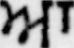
ਆ
